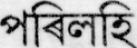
পৰিলহি
